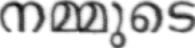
നമ്മുടെ
